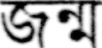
জন্ম
